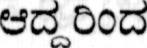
ಆದ್ದರಿಂದ
